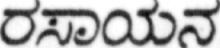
ರಸಾಯನ
